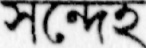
সন্দেহ
